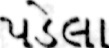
પડેલા
